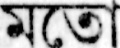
মতো
